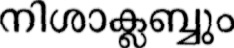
നിശാക്ലബ്ബും
